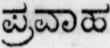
ಪ್ರವಾಹ
